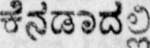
ಕೆನಡಾದಲ್ಲಿ
